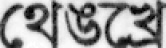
থেঙখ্রে
